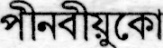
পীনবীয়ুকো
